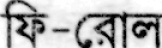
ফি-রোল
